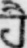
ਹੈ
